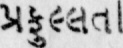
પ્રફુલ્લતા
